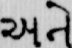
અને
